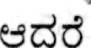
ಆದರೆ
